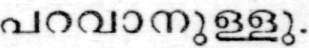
പറവാനുള്ളു.
